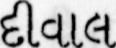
દીવાલ
